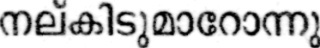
നല്കിടുമാറോന്നു
